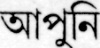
আপুনি
